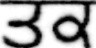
ਤਕ
